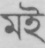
মই
